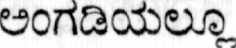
ಅಂಗಡಿಯಲ್ಲೂ
